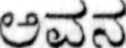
ಅವನ
